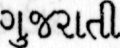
ગુજરાતી
